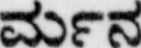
ರ್ಮನ
